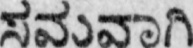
ಸಮವಾಗಿ
